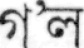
গ'ল
